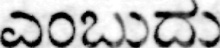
ಎಂಬುದು
